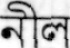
নীল
